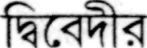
দ্বিবেদীর
